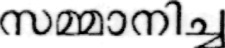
സമ്മാനിച്ച
